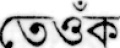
তেওঁক
